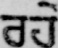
ਰਹੇ
